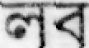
লব
